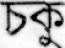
চকু
